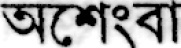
অশেংবা
